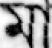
মা
